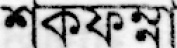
শকফম্না
